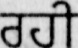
ਰਹੀ
